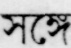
সঙ্গে
